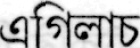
এগিলাচ
